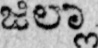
ಜಿಲ್ಲಾ
